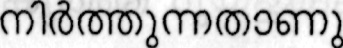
നിര്‍ത്തുന്നതാണു
